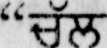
''ਚੱਲ
